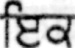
ਇਕ
